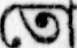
তো
